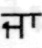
ਜਾ
